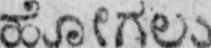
ಹೋಗಲು
